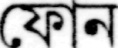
ফোন
